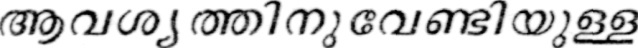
ആവശ്യത്തിനുവേണ്ടിയുള്ള
